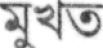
মুখত
